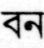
বন
